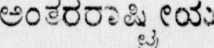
ಅಂತರರಾಷ್ಟ್ರೀಯ
